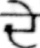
ਦੇ
